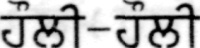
ਹੌਲੀ-ਹੌਲੀ
